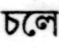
চলে
